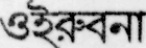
ওইরুবনা
